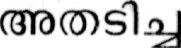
അതടിച്ച
